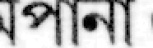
মপানা
